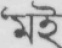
'মই
